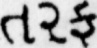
તરફ
